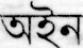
অইন
